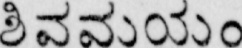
ಶಿವಮಯಂ
